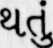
થતું
